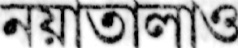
নয়াতালাও
